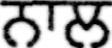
ਨਾਲ
